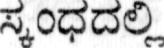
ಸ್ಕಂಧದಲ್ಲಿ
